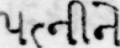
પત્નીને
